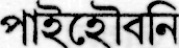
পাইহৌবনি
